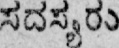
ಸದಸ್ಯರು
